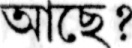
আছে?
